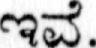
ಇವೆ.
